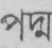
পদ্ম
